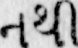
નથી
